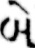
બે
